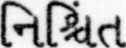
નિશ્ચિંત
